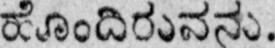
ಹೊಂದಿರುವನು.
